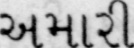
અમારી
